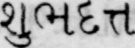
શુભદત્ત
